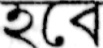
হবে
